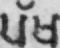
ਪੱਖ
